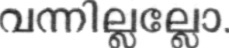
വന്നില്ലല്ലോ.
